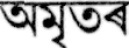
অমৃতৰ
